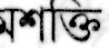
মশক্তি
